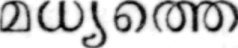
മധ്യത്തെ
